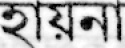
হায়না
